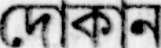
দোকান
